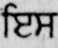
ਇਸ
